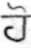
ਹੋ
